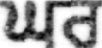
ਘਰ
